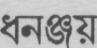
ধনঞ্জয়
